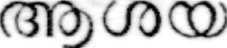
ആശയ
